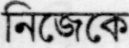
নিজেকে
